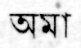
অমা
